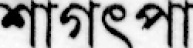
শাগৎপা
